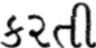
કરતી
